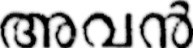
അവന്‍
